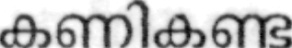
കണികണ്ട
